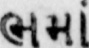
ભમાં
